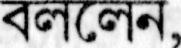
বললেন,
